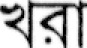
খরা
